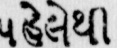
પહેલેથી
